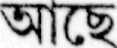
আছে
